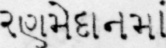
રણમેદાનમાં
